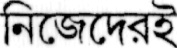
নিজেদেরই
